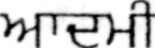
ਆਦਮੀ
